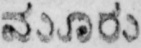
ಮೂರು
